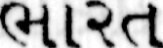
ભારત
